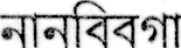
নানবিবগা
